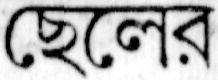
ছেলের
